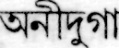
অনীদুগা
